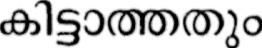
കിട്ടാത്തതും
